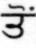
ਤੋਂ
